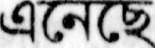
এনেছে
